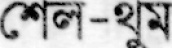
শেল-থুম
